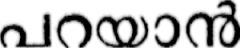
പറയാന്‍
